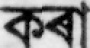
কৰা
